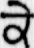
ਕੇ
